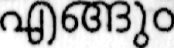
എങ്ങും
